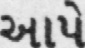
આપે
